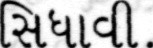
સિધાવી.
